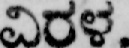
ವಿರಳ.
